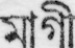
মাগী
